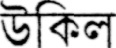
উকিল
